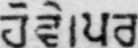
ਹੋਵੇ।ਪਰ
